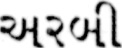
અરબી
